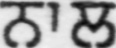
ਨਾਲ
